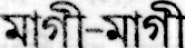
মাগী-মাগী
